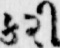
કરી
